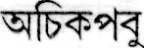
অচিকপবু
